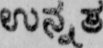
ಉನ್ನತ
